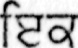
ਇਕ
